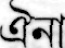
ঐনা
